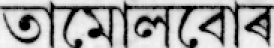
তামোলবোৰ
